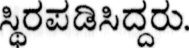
ಸ್ಥಿರಪಡಿಸಿದ್ದರು.
